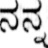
ನನ್ನ
